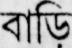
বাড়ি
